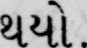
થયો.
